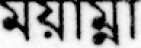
ময়াম্না
